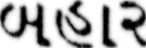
બહાર
